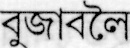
বুজাবলৈ
